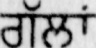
ਗੱਲਾਂ
